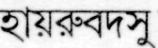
হায়রুবদসু
